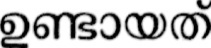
ഉണ്ടായത്
